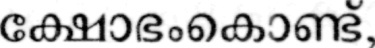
ക്ഷോഭംകൊണ്ട്,
